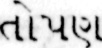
તોપણ
